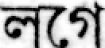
লগে
